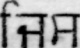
ਜਿਸ
